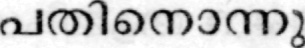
പതിനൊന്നു
